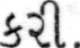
કરી.
